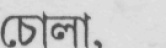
চোলা,
